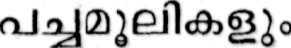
പച്ചമൂലികളും
